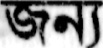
জন্য
